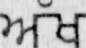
ਅੱਖ
